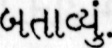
બતાવ્યું.
